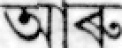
আৰু
